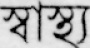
স্বাস্হ্য
